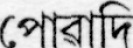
পোৱাদি
